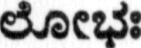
ಲೋಭಃ
